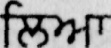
ਲਿਆ
